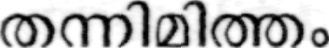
തന്നിമിത്തം
